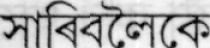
সাৰিবলৈকে
